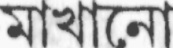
মাখানো
